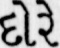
દોરે
